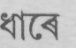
ধাৰে
